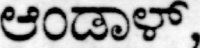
ಆಂಡಾಳ್,
